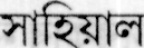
সাহিয়াল
